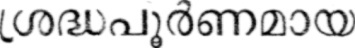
ശ്രദ്ധപൂര്‍ണമായ
